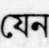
যেন
